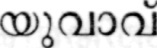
യുവാവ്
